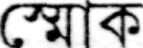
স্মোক
